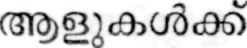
ആളുകള്‍ക്ക്
